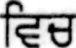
ਵਿਚ
